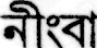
নীংবা
